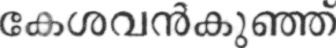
കേശവന്‍കുഞ്ഞ്
